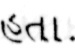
હતા.
